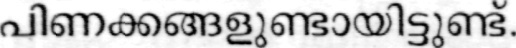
പിണക്കങ്ങളുണ്ടായിട്ടുണ്ട്.
